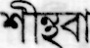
শীন্থবা
